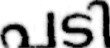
പടി
